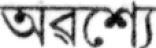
অৱশ্যে
